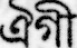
ঐগী
